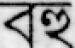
বহু
